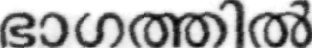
ഭാഗത്തില്‍
